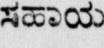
ಸಹಾಯ
